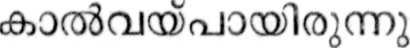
കാല്‍വയ്പായിരുന്നു
